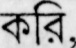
করি,
